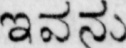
ಇವನು
